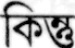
কিন্তু
